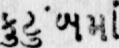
કુટુંબમાં
